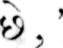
છે,'
